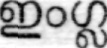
ഇംഗ്ല
